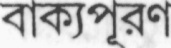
বাক্যপূরণ
